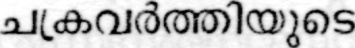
ചക്രവര്‍ത്തിയുടെ
